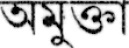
অমুক্তা
